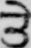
ਤੇ
